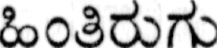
ಹಿಂತಿರುಗು
